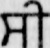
ਸੀ
